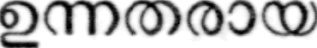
ഉന്നതരായ
